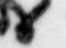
જ
